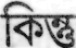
কিন্তু
